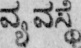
ವ್ಯವಸ್ಥೆ
